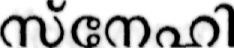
സ്നേഹി
